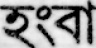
হংবা
